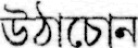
উঠাচোন
